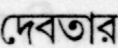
দেবতার
